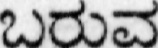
ಬರುವ
